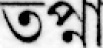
তপ্না
